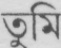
তুমি
